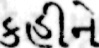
કહીને
